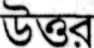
উত্তর
